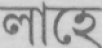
লাহে
